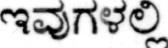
ಇವುಗಳಲ್ಲಿ
